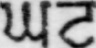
ਘਟ
